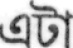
এটা
